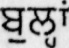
ਬੁਲ੍ਹਾਂ
